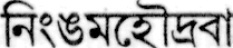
নিংঙমহৌদ্রবা
